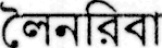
লৈনরিবা
